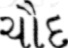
ચૌદ
